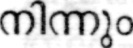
നിന്നും
